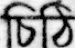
চিঠি
